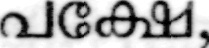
പക്ഷേ,
